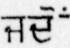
ਜਦੋਂ
